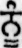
ਨੂੰ
